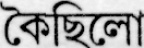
কৈছিলো
